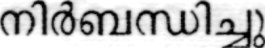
നിര്‍ബന്ധിച്ചു
